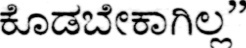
ಕೊಡಬೇಕಾಗಿಲ್ಲ"
